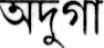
অদুগা
